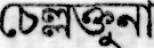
চেল্লক্তুনা
